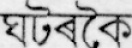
ঘটৰকৈ
